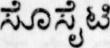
ಸೊಸೈಟಿ
